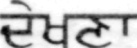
ਦੇਖਣਾ
